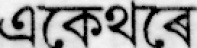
একেথৰে
